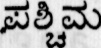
ಪಶ್ಚಿಮ
